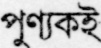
পুণ্যকই
